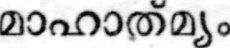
മാഹാത്മ്യം
